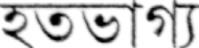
হতভাগ্য
